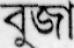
বুজা
